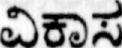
ವಿಕಾಸ
